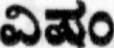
ವಿಷಂ
